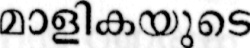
മാളികയുടെ
